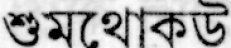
শুমথোকউ
